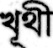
খূথী
